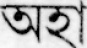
অহা
